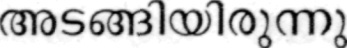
അടങ്ങിയിരുന്നു
